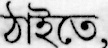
ঠাইতে,
